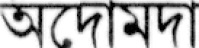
অদোমদা
